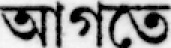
আগতে
